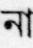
না
